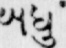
બધું
